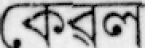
কেৱল
